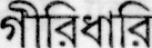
গীরিধারি
